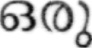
ഒരു
